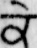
ਕੇ
